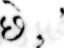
છે,'
